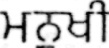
ਮਨੁਖੀ
